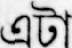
এটা
